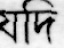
যদি
